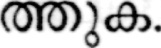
ത്തുക.
